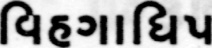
વિહગાધિપ
